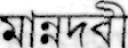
মান্নদবী
